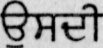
ਉਸਦੀ
